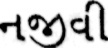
નજીવી
